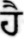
ਹੈ
